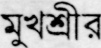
মুখশ্রীর
